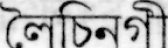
লৈচিনগী
